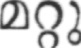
മറ്റു
